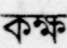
কক্ষ
